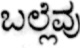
ಬಲ್ಲೆವು
